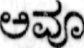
ಅವೂ
